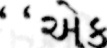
"એક
